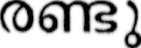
രണ്ടു
